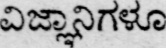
ವಿಜ್ಞಾನಿಗಳೂ
